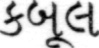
કબૂલ
